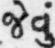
જેવું
